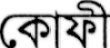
কোফী
